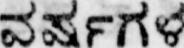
ವರ್ಷಗಳ
